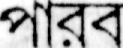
পারব
